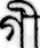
গী
